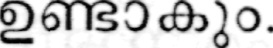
ഉണ്ടാകും.
